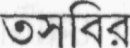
তসবির
